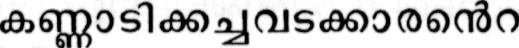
കണ്ണാടിക്കച്ചവടക്കാരന്റെ
